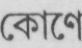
কোণে
